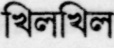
খিলখিল
